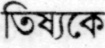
তিষ্যকে
